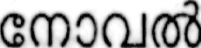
നോവല്‍
